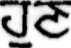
ਹੁਣ
